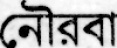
নৌরবা
